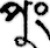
পুং
